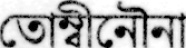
তোম্বীনৌনা
